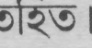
তহিত
